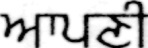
ਆਪਣੀ
